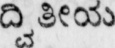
ದ್ವೀತಿಯ
